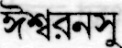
ঈশ্বরনসু
